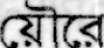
য়ৌরে
